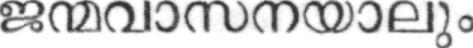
ജന്മവാസനയാലും
